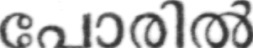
പോരില്‍
